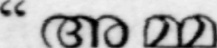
"അമ്മ
